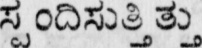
ಸ್ಪಂದಿಸುತ್ತಿತ್ತು
